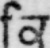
ਕਿ
